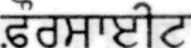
ਫ਼ੌਰਸਾਈਟ
